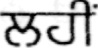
ਲਹੀਂ
